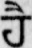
ਹੈ
